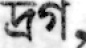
দ্রগ,
